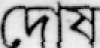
দোষ
